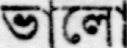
ভালো
